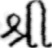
શ્રી
